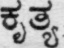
ಕೃತ್ಯ
